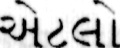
એટલો
